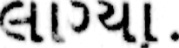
લાગ્યા.
